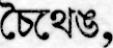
চৈথেঙ,
